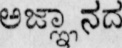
ಅಜ್ಞಾನದ
